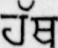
ਹੱਥ
